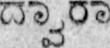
ದ್ವಾರಾ
